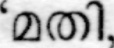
‘മതി,
